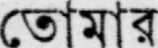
তোমার
